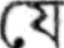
যে
